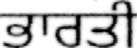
ਭਾਰਤੀ
